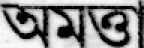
অমত্তা
